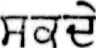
ਸਕਦੇ
